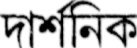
দার্শনিক
